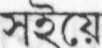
সইয়ে
